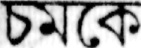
চমকে
